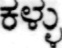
ಕಳ್ಳು
